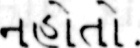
નહોતો.
